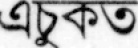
এচুকত
